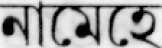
নামেহে
